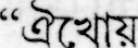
“ঐখোয়
